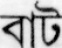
বাট
